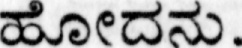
ಹೋದನು.
